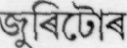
জুৰিটোৰ
